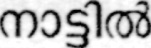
നാട്ടില്‍
